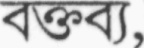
বক্তব্য,
